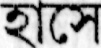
হাসে
